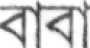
বাবা
